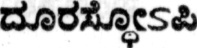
ದೂರಸ್ಧೋsಪಿ
